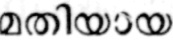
മതിയായ
